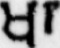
ਖਾ
